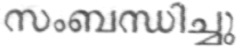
സംബന്ധിച്ചു
